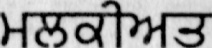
ਮਲਕੀਅਤ
